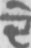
ਦੇ
